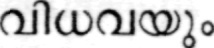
വിധവയും
